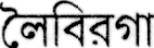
লৈবিরগা
